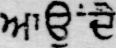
ਆਉਂਦੇ
